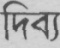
দিব্য
